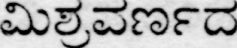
ಮಿಶ್ರವರ್ಣದ
